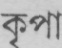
কৃপা
